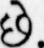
છે.
